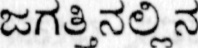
ಜಗತ್ತಿನಲ್ಲಿನ
